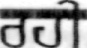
ਰਹੀ
